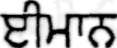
ਈਮਾਨ
